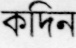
কদিন
